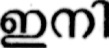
ഇനി
